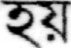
হয়
